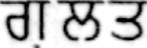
ਗ਼ਲਤ
